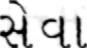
સેવા
